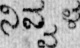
ನಿವ್ವಳ
